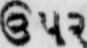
ઉપર
